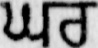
ਘਰ
